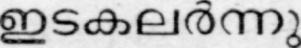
ഇടകലര്‍ന്നു
